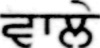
ਵਾਲੇ
